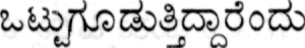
ಒಟ್ಟುಗೂಡುತ್ತಿದ್ದಾರೆಂದು
